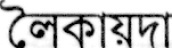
লৈকায়দা
